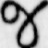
જ
